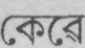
কেৱে
